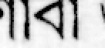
শাবা
